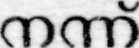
നന്ന്
